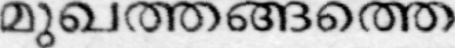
മുഖത്തങ്ങത്തെ
